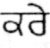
ਕਰੇ
